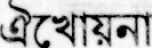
ঐখোয়না
